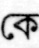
কে
